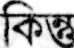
কিন্তু
